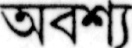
অবশ্য
